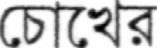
চোখের
